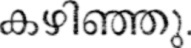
കഴിഞ്ഞു.
